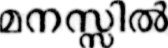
മനസ്സില്‍
